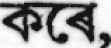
কৰে,
